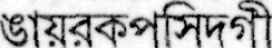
ঙায়রকপসিদগী
